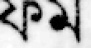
ফম
